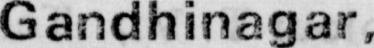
Gandhinagar,
